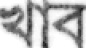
খাব
